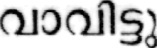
വാവിട്ടു
